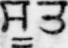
ਸੂਤ
